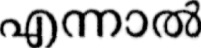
എന്നാല്‍
